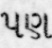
પણ
